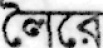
লৈরে
